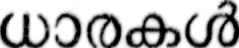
ധാരകള്‍
